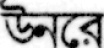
উনরে
